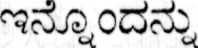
ಇನ್ನೊಂದನ್ನು
